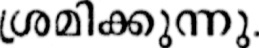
ശ്രമിക്കുന്നു.
